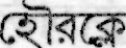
হৌরক্লে
